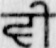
ਵੀ
